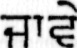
ਜਾਵੇ
